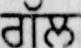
ਗੱਲ
